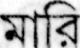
মারি
